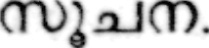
സൂചന.
